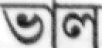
ভাল
